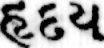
હ્રદય
